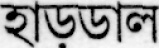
হাড়ডাল
